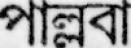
পাল্লবা
